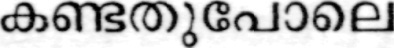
കണ്ടതുപോലെ
